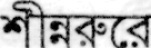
শীন্নরুরে
